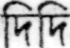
দিদি
